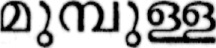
മുമ്പുള്ള
